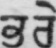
ਭਰੇ
